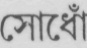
সোধোঁ
